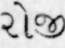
રોજી
